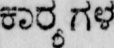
ಕಾರ್‍ಯಗಳ
